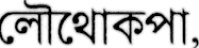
লৌথোকপা,
